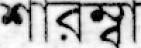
শারম্বা
